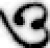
ও
